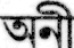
অনী
